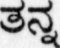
ತನ್ನ
